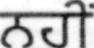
ਨਹੀਂ
